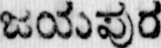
ಜಯಪುರ
